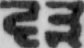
ਵੜ
